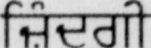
ਜ਼ਿੰਦਗੀ
